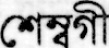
শেম্বগী
